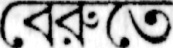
বেরুতে
